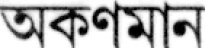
অকণমান
